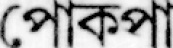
পোকপা
